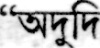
“অদুদি
